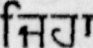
ਜਿਹਾ
